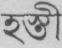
হস্তী
